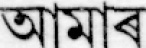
আমাৰ
